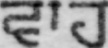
ਵਾਹ
